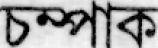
চম্পাক
